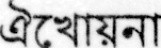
ঐখোয়না
